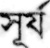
সূর্য
